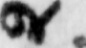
જ.
